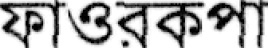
ফাওরকপা
